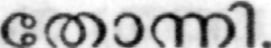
തോന്നി.
